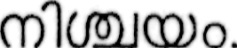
നിശ്ചയം.
